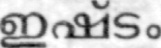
ഇഷ്ടം
